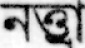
নত্ত্রা
